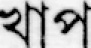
খাপ
